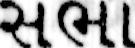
સભા
